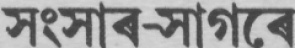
সংসাৰ-সাগৰে
